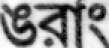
ঙরাং
